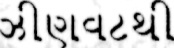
ઝીણવટથી
